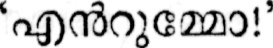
‘എന്‍റുമ്മോ!’
